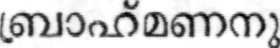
ബ്രാഹ്മണനു
